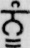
ਨੂੰ
